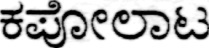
ಕಪೋಲಾಟ
